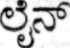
ಲೈನ್
